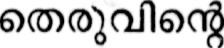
തെരുവിന്റെ
